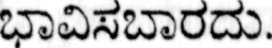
ಭಾವಿಸಬಾರದು.
